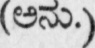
(ಅನು.)
